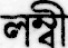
লম্বী
